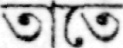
তাতে
